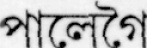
পালেগৈ
